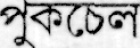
পুকচেল
